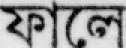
ফালে
